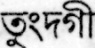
তুংদগী
